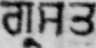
ਗ੍ਰਸਤ
